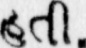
હતી.
